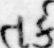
તર્ક
